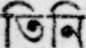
তিনি
